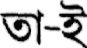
তা-ই
